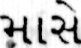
માસે
